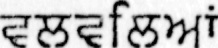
ਵਲਵਲਿਆਂ
